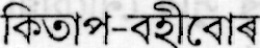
কিতাপ-বহীবোৰ
